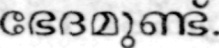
ഭേദമുണ്ട്.
